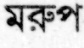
মরুপ
